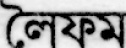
লৈফম
